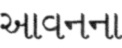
આવનના
